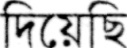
দিয়েছি
